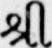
શ્રી
